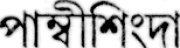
পাম্বীশিংদা
